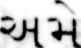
અમે
